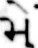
મેં
